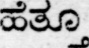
ಹೆತ್ತೂ
